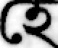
হে
